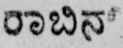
ರಾಬಿನ್
